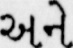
અને
